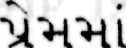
પ્રેમમાં
